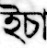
ইচা
